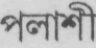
পলাশী
